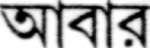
আবার
